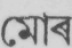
মোৰ
